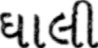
ઘાલી
